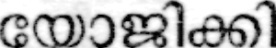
യോജിക്കി
